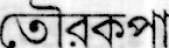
তৌরকপা
